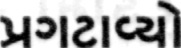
પ્રગટાવ્યો
